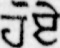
ਹੋਏ
